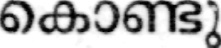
കൊണ്ടു
